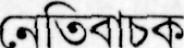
নেতিবাচক
